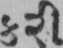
કરી
